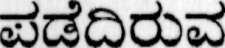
ಪಡೆದಿರುವ
